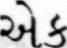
એક
